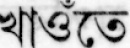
খাওঁতে
